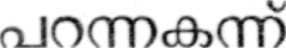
പറന്നകന്ന്
